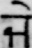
ਜੇ
